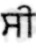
ਸੀ
